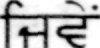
ਜਿਵੇਂ
